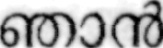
ഞാന്‍
